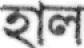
হাল
